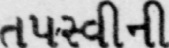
તપસ્વીની
